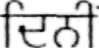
ਦਿਨੀਂ
